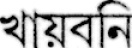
খায়বনি
